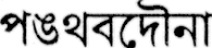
পঙথবদৌনা
